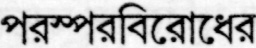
পরস্পরবিরোধের
